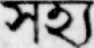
সহ্য
